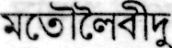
মতৌলৈবীদু
